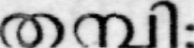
തമ്പി:
